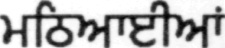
ਮਠਿਆਈਆਂ
